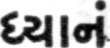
ધ્યાનં
